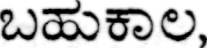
ಬಹುಕಾಲ,
